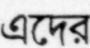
এদের
